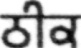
ਠੀਕ
